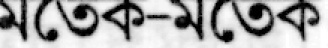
মতেক-মতেক
